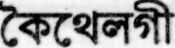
কৈথেলগী
